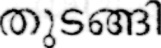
തുടങ്ങി
